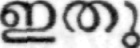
ഇതു
